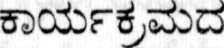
ಕಾರ್ಯಕ್ರಮದ
